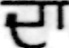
ਦਾ
